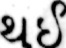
થઈ
